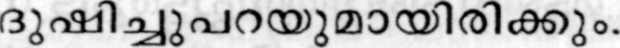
ദുഷിച്ചുപറയുമായിരിക്കും.
